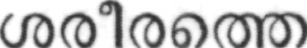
ശരീരത്തെ
